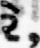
રે,
